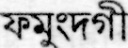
ফমুংদগী
